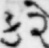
કરે
